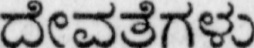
ದೇವತೆಗಳು
